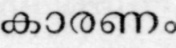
കാരണം
